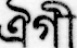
ঐগী
